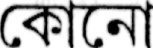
কোনো
